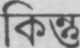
কিন্তু
